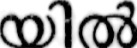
യില്‍
